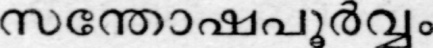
സന്തോഷപൂര്‍വ്വം
